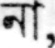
না,
